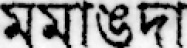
মমাঙদা
